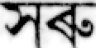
সৰু
